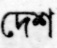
দেশ
